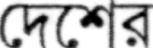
দেশের
